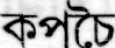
কপচৈ
